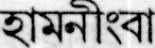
হামনীংবা
